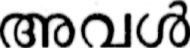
അവള്‍
